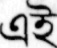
এই
